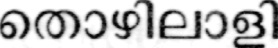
തൊഴിലാളി
